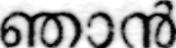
ഞാന്‍
